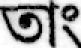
তাং
